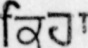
ਕਿਹਾ
